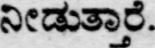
ನೀಡುತ್ತಾರೆ.
